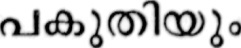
പകുതിയും
